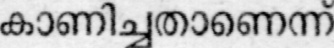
കാണിച്ചതാണെന്ന്
